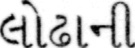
લોઢાની
